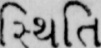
સ્થિતિ
